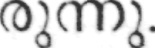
രുന്നു.
